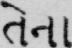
તેના
